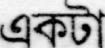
একটা
